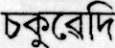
চকুৱেদি
